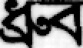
ধ্রুব
